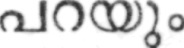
പറയും
